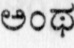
ಅಂಥ
